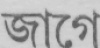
জাগে
